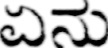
ಏನು
